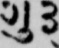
ગુરૂ
